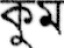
কুম
